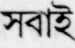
সবাই
